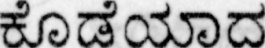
ಕೊಡೆಯಾದ
